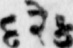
દરેક
